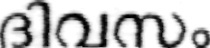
ദിവസം
